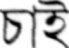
চাই
